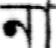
না
